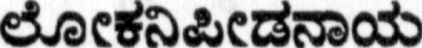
ಲೋಕನಿಪೀಡನಾಯ
